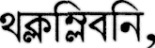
থক্লম্লিবনি,
